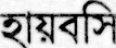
হায়বসি
